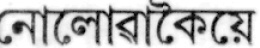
নোলোৱাকৈয়ে
